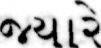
જ્યારે
